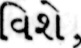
વિશે,
